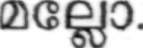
മല്ലോ.
